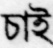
চাই
